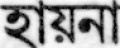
হায়না
